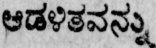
ಆಡಳಿತವನ್ನು
